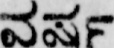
ವರ್ಷ
